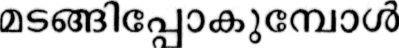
മടങ്ങിപ്പോകുമ്പോള്‍
